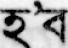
হ'ব
